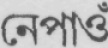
নেপাওঁ
